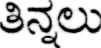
ತಿನ್ನಲು
